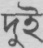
দুই
